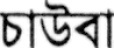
চাউবা
